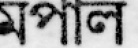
মপাল
